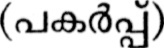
(പകര്‍പ്പ്)
